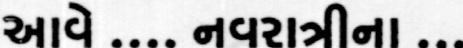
આવે........નવરાત્રીના......
